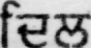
ਦਿਲ
